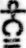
ਨੂੰ
